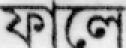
ফালে
